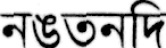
নঙতনদি
